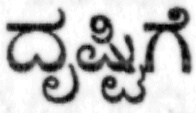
ದೃಷ್ಟಿಗೆ
